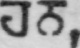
ਹਨ,
